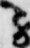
કે
